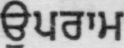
ਉਪਰਾਮ
